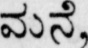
ಮನೆ,
